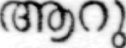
ആറു
